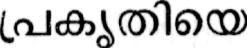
പ്രകൃതിയെ
